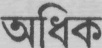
অধিক
